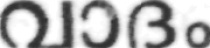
വാദം
